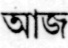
আজ
